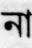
না
